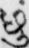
છું
